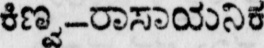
ಕಿಣ್ವ-ರಾಸಾಯನಿಕ
